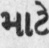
માટે
